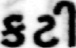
કટી
